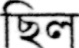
ছিল
